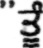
''ਤੂੰ
